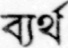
ব্যর্থ
